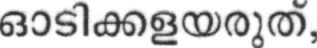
ഓടിക്കളയരുത്,
